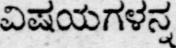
ವಿಷಯಗಳನ್ನ
